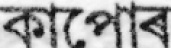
কাপোৰ
